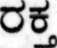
ರಕ್ತ
